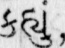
કહ્યું,
